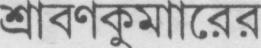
শ্রাবণকুমারের
